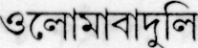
ওলোমাবাদুলি
